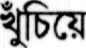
খুঁচিয়ে
